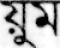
য়ুম
